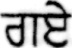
ਗਏ
